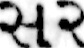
સર
